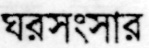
ঘরসংসার
